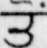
ਤੋਂ
